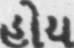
હોય
